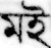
মই
